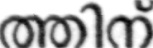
ത്തിന്
